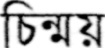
চিন্ময়
